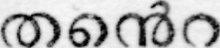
തന്റെ
